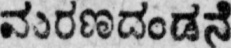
ಮರಣದಂಡನೆ
